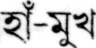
হাঁ-মুখ
